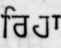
ਰਿਹਾ
